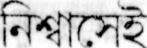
নিশ্বাসেই
